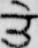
ਤੇ
